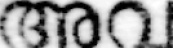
അവ
